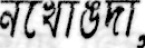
নখোঙদা,
